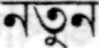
নতুন
